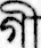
গী
